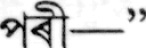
পৰী-"
